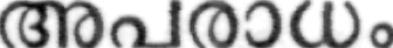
അപരാധം
